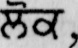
ਲੋਕ,
